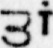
ਤਾਂ
